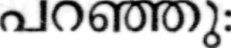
പറഞ്ഞു:
